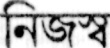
নিজস্ব
